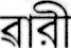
ৱারী
